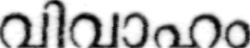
വിവാഹം
